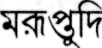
মরূপ্তুদি
